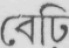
বেঢ়ি
